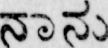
ನಾನು
